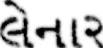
લેનાર
